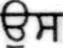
ਉਸ
